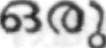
ഒരു
